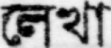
লেখা
